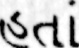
હતાં
